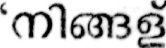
‘നിങ്ങള്
